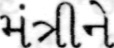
મંત્રીને
